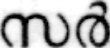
സര്‍
